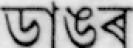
ডাঙৰ
